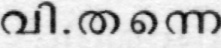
വി.തന്നെ
